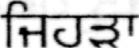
ਜਿਹੜਾ
